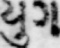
યુગ
